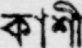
কাশী
